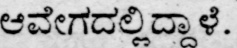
ಆವೇಗದಲ್ಲಿದ್ದಾಳೆ.
